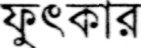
ফুত্কার
